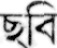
ছবি
